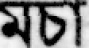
মচা
